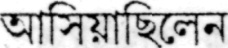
আসিয়াছিলেন
